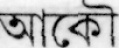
আকৌ
